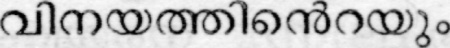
വിനയത്തിന്റെയും
